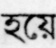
হয়ে
